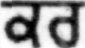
ਕਰ
